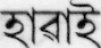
হাৱাই
